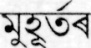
মুহূর্তৰ
